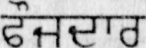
ਫੌਜਦਾਰ
